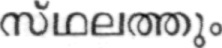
സ്ഥലത്തും
